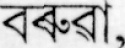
বৰুৱা,
